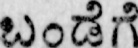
ಬಂಡೆಗೆ
